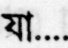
যা...
